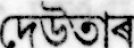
দেউতাৰ
